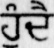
ਹੁੰਦੈ
